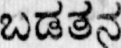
ಬಡತನ
